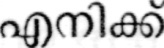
എനിക്ക്
